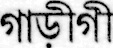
গাড়ীগী
